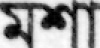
মশা
